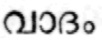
വാദം
